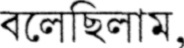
বলেছিলাম,
